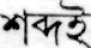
শব্দই
